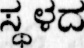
ಸ್ಥಳದ
